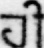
ਹੀ
